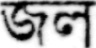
জল
